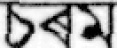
চৰম
